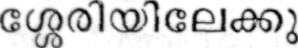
ശ്ശേരിയിലേക്കു
